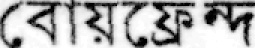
বোয়ফ্রেন্দ
